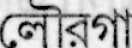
লৌরগা
